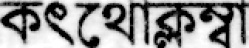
কৎথোক্লম্বা
